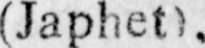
(Japhet),
